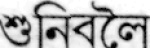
শুনিবলৈ
